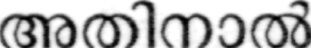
അതിനാല്‍
